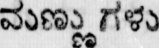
ಮಣ್ಣುಗಳು
